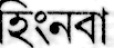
হিংনবা
